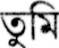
তুমি
